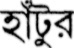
হাঁটুর
